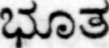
ಭೂತ
